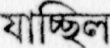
যাচ্ছিল
